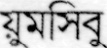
য়ুমসিবু
